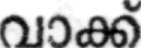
വാക്ക്
